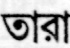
তারা
